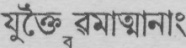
যুক্তৈৱমাত্মানাং
